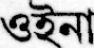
ওইনা
